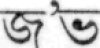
জ'ভ
